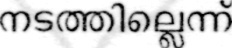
നടത്തില്ലെന്ന്
